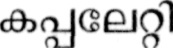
കപ്പലേറ്റി
